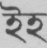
ইহ
